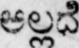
ಅಲ್ಲದೆ
